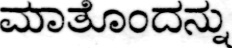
ಮಾತೊಂದನ್ನು
